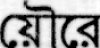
য়ৌরে
